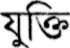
যুক্তি
